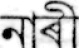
নাৰী
